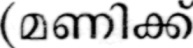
(മണിക്ക്
